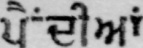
ਪੈਂਦੀਆਂ
